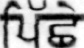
ਪਿੱਛੇ
